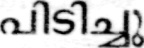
പിടിച്ചു
